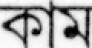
কাম
